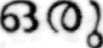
ഒരു
